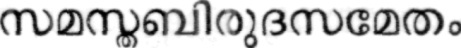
സമസ്തബിരുദസമേതം
